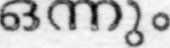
ഒന്നും
